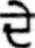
ਦੇ
